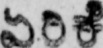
ಏರಿಕೆ
